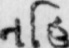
નહિ
